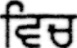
ਵਿਚ
